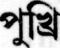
পুখ্রি
